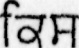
ਕਿਸ
